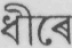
ধীৰে
